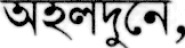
অহলদুনে,
